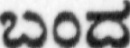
ಬಂದ
